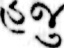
હજુ
